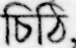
চিঠি,
